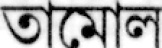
তামোল
